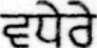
ਵਧੇਰੇ
